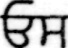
ਓਸ
